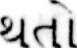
થતો
